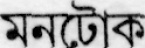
মনটোক
